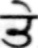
ਤੇ
